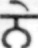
ਨੇ
